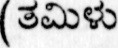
(ತಮಿಳು
